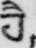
ਹੈ,
